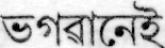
ভগৱানেই
